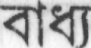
বাধ্য
